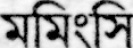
মমিংসি
